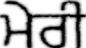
ਮੇਰੀ
